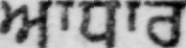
ਆਧਾਰ
